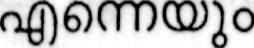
എന്നെയും
